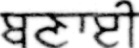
ਬਣਾਈ
